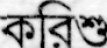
করিশু
